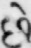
છે
